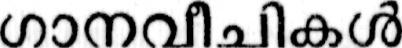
ഗാനവീചികള്‍
